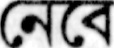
নেবে
